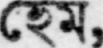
হেম,
